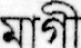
মাগী
